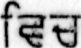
ਵਿਚ
